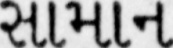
સામાન
